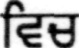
ਵਿਚ
